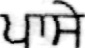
ਪਾਸੇ
